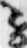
કે
